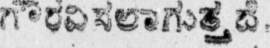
ಗೌರವಿಸಲಾಗುತ್ತದೆ.
